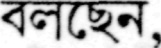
বলছেন,
